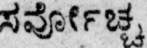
ಸರ್ವೋಚ್ಚ
